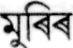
মুৰিৰ
